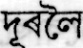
দূৰলৈ
